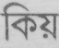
কিয়
